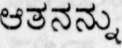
ಆತನನ್ನು
